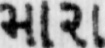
મારા
